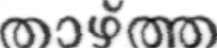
താഴ്ത്ത
